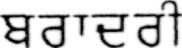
ਬਰਾਦਰੀ
